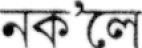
নক'লে
